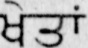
ਖੇਤਾਂ
